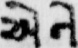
એને
